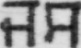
ਜਸ
